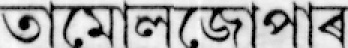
তামোলজোপাৰ
